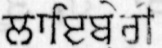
ਲਾਇਬ੍ਰੇਰੀ
